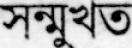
সন্মুখত
